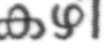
കഴി
